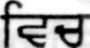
ਵਿਚ
